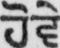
ਹੋਵੇ
